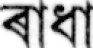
ৰাধা
